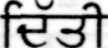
ਦਿੱਤੀ
